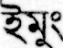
ইমুং
